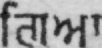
ਗਿਆ
